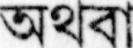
অথবা
